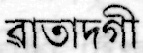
ৱাতাদগী
